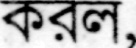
করল,
